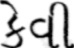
કેવી
